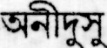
অনীদুসু
